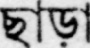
ছাড়া
